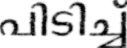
പിടിച്ച്
